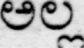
ಅಲ್ಲ
